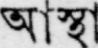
আস্থা
